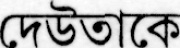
দেউতাকে
